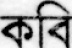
কবি
